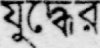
যুদ্ধের
